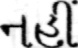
નહીં
